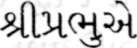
શ્રીપ્રભુએ
